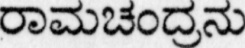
ರಾಮಚಂದ್ರನು
